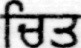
ਚਿਤ
